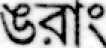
ঙরাং
